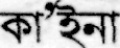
কা’ইনা
